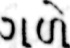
ગળે
